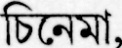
চিনেমা,
